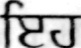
ਇਹ
